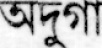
অদুগা
